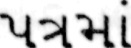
પત્રમાં
